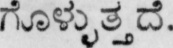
ಗೊಳ್ಳುತ್ತದೆ.
